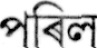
পৰিল
